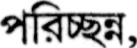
পরিচ্ছন্ন,
